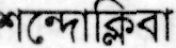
শন্দোক্লিবা
